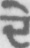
ਦੇ
